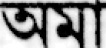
অমা
